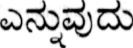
ಎನ್ನುವುದು
